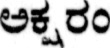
ಅಕ್ಷರಂ
